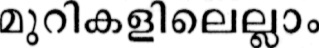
മുറികളിലെല്ലാം
